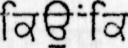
ਕਿਉਂਕਿ
